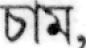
চাম,
